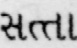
સત્તા
